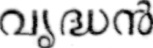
വൃദ്ധന്‍
